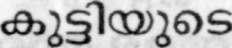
കുട്ടിയുടെ
